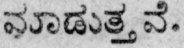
ಮಾಡುತ್ತವೆ.
